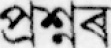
প্রশ্নৰ
